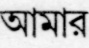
আমার
